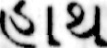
હાથ
